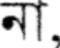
না,
